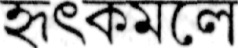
হৃত্কমলে
